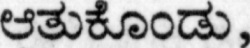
ಆತುಕೊಂಡು,
